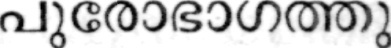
പുരോഭാഗത്തു
